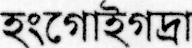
হংগোইগদ্রা
